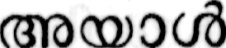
അയാള്‍
